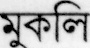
মুকলি
